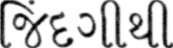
જિંદગીથી
